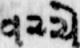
વચ્ચે
